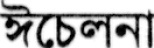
ঈচেলনা
